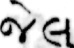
જેલ
